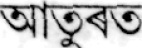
আতুৰত
